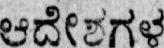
ಆದೇಶಗಳ
